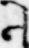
ને
